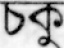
চকু
